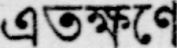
এতক্ষণে
